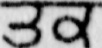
ਤਕ
